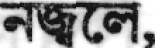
নজ্বলে,
